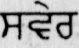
ਸਵੇਰ
